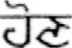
ਹੋਣ
